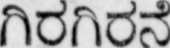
ಗಿರಗಿರನೆ
